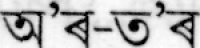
অ'ৰ-ত'ৰ
